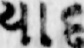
યાદ
